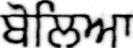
ਬੋਲਿਆ
